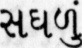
સઘળું
